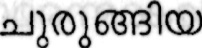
ചുരുങ്ങിയ
